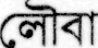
লৌবা
